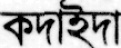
কদাইদা
